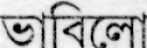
ভাবিলো
